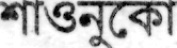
শাওনুকো
